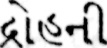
દ્રોહની
